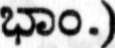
ಭಾಂ.)
